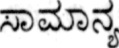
ಸಾಮಾನ್ಯ
